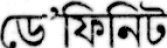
ডে'ফিনিট
